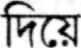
দিয়ে
